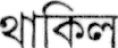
থাকিল
